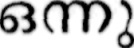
ഒന്നു
